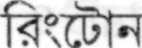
রিংটোন
